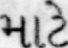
માટે
